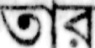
তার
